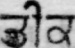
ਤੀਕ
